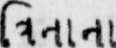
વિનાના
